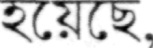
হয়েছে,
